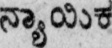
ನ್ಯಾಯಿಕ
